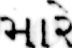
મારે
